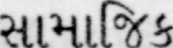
સામાજિક
